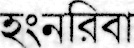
হংনরিবা
